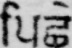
ਪਿਛੇ
